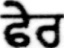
ਫੇਰ
